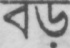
বড়
